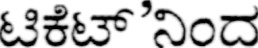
ಟಿಕೆಟ್'ನಿಂದ
